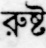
রুষ্ট
